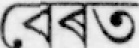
বেৰত
